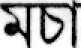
মচা
